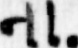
ના.
